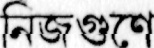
নিজগুণে
